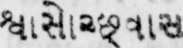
શ્વાસોચ્છવાસ
